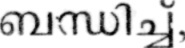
ബന്ധിച്ച്,
